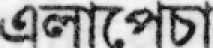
এলাপেচা
